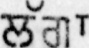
ਲੱਗਾ
